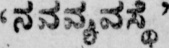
‘ನವವ್ಯವಸ್ಥೆ’
